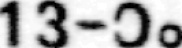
13-ാം
